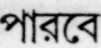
পারবে
